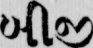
બીજી
